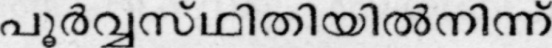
പൂര്‍വ്വസ്ഥിതിയില്‍നിന്ന്
